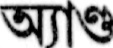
অ্যাণ্ড
